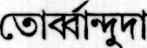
তোর্ব্বান্দুদা
